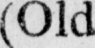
(Old
